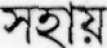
সহায়
